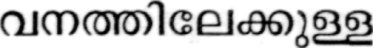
വനത്തിലേക്കുള്ള
